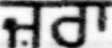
ਜ਼ਰਾ
